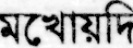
মখোয়দি
